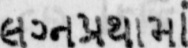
લગ્નપ્રથામાં
